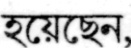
হয়েছেন,
